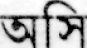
অসি
